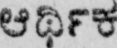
ಆರ್ಥಿಕ
